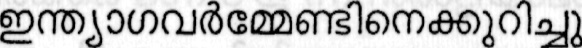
ഇന്ത്യാഗവര്‍മ്മേണ്ടിനെക്കുറിച്ചു
